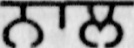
ਨਾਲ
